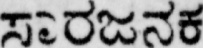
ಸಾರಜನಕ
